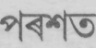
পৰশত
